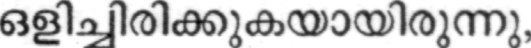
ഒളിച്ചിരിക്കുകയായിരുന്നു,
